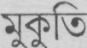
মুকুতি
